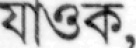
যাওক,
